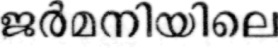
ജര്‍മനിയിലെ
